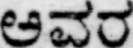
ಅವರ
